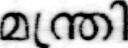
മന്ത്രി
